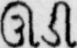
ઊડી
